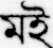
মই
